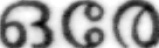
ഒരേ
